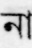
না
